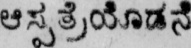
ಆಸ್ಪತ್ರೆಯೊಡನೆ
